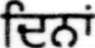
ਦਿਨਾਂ
